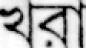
খরা
